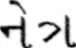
નેત્ર
